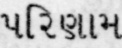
પરિણામ
